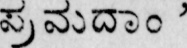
ಪ್ರಮದಾಂ’
